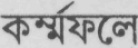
কৰ্ম্মফলে
